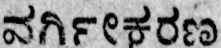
ವರ್ಗೀಕರಣ
